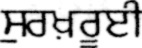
ਸੁਰਖ਼ਰੂਈ
